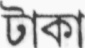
টাকা
